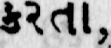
કરતા,
